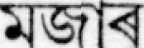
মজাৰ
